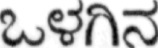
ಒಳಗಿನ
